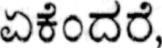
ಏಕೆಂದರೆ,
